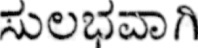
ಸುಲಭವಾಗಿ
